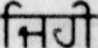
ਜਿਹੀ
